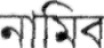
নামিব
